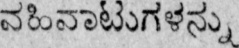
ವಹಿವಾಟುಗಳನ್ನು
